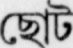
ছোট
